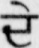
ਦੇ
